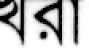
খরা
